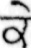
ਕੇ
